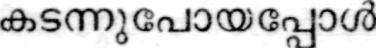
കടന്നുപോയപ്പോള്‍
